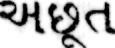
અછૂત
